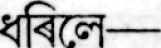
ধৰিলে-
